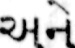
અને
